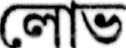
লোভ
